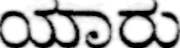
ಯಾರು
